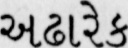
અઢારેક
